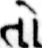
તો
